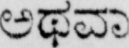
ಅಥವಾ
